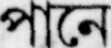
পানে
